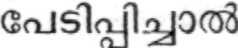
പേടിപ്പിച്ചാല്‍
